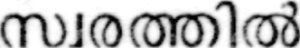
സ്വരത്തില്‍
